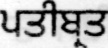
ਪਤੀਬ੍ਰਤ
